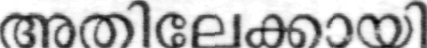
അതിലേക്കായി
